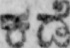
ಕಡೆ
